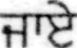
ਜਾਏ
